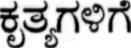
ಕೃತ್ಯಗಳಿಗೆ
